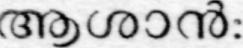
ആശാന്‍:
